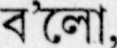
ব'লো,
